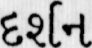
દર્શન
